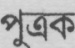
পুত্ৰক
